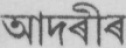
আদৰীৰ
